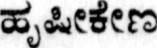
ಹೃಷೀಕೇಣ
